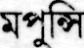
মপুন্সি
